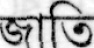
জাতি
